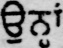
ਉਨ੍ਹਾਂ
